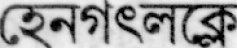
হেনগৎলক্লে
